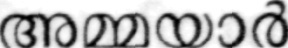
അമ്മയാര്‍
